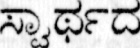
ಸ್ವಾರ್ಥದ
